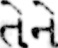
તેને
